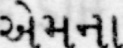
એમના
